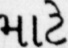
માટે
